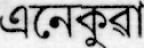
এনেকুৱা
